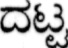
ದಟ್ಟ
